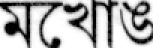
মখোঙ
